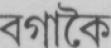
বগাকৈ
